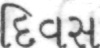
દિવસ
